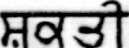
ਸ਼ਕਤੀ
